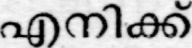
എനിക്ക്
